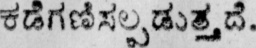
ಕಡೆಗಣಿಸಲ್ಪಡುತ್ತದೆ.
